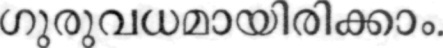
ഗുരുവധമായിരിക്കാം.
